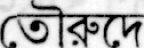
তৌরুদে
